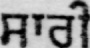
ਸਾਰੀ
